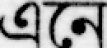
এনে
